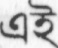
এই
